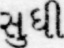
સુધી
